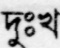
দুঃখ
